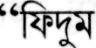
“ফিদুম
